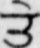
ਤੇ
